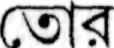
তোর
